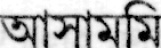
আসামমি
